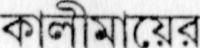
কালীমায়ের
